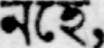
নহে,
